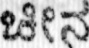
ಚೀನ
